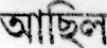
আছিল
